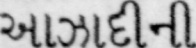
આઝાદીની
